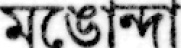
মঙোন্দা
